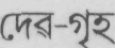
দেৱ-গৃহ
